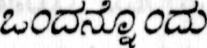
ಒಂದನ್ನೊಂದು
